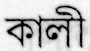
কালী
